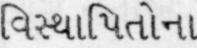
વિસ્થાપિતોના
